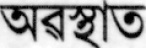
অৱস্থাত
